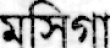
মসিগা
